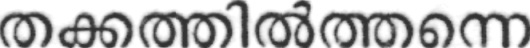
തക്കത്തില്‍ത്തന്നെ
